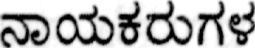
ನಾಯಕರುಗಳ
